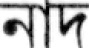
নাদ
